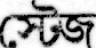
স্টেজ
